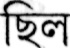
ছিল
